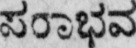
ಪರಾಭವ
